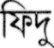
ফিদু
